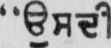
''ਉਸਦੀ
